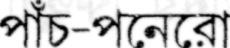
পাঁচ-পনেরো
